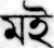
মই
